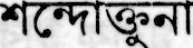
শন্দোক্তুনা
